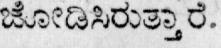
ಜೋಡಿಸಿರುತ್ತಾರೆ.
